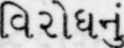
વિરોધનું
